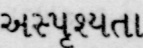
અસ્પૃશ્યતા
